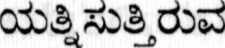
ಯತ್ನಿಸುತ್ತಿರುವ
